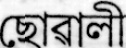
ছোৱালী
